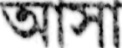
আসা
